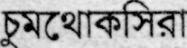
চুমথোকসিরা
